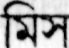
মিস
